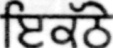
ਇਕੱਠੇ
